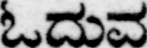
ಓದುವ
